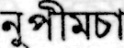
নুপীমচা
